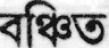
বঞ্চিত
